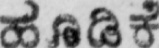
ಹೂಡಿಕೆ
